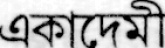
একাদেমী
